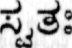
ಸ್ವತಃ
